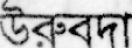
উরুবদা
